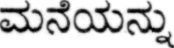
ಮನೆಯನ್ನು
